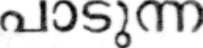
പാടുന്ന
